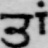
ਤਾਂ
